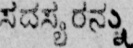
ಸದಸ್ಯರನ್ನು
